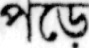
পড়ে
